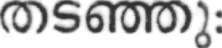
തടഞ്ഞു:
